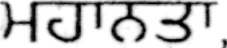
ਮਹਾਨਤਾ,
